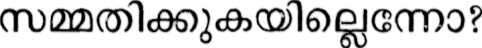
സമ്മതിക്കുകയില്ലെന്നോ?
